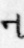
ન
